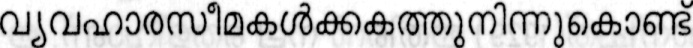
വ്യവഹാരസീമകള്‍ക്കകത്തുനിന്നുകൊണ്ട്
